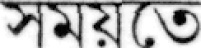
সময়তে
